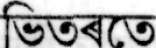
ভিতৰতে
